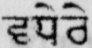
ਵਧੇਰੇ
